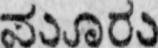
ಮೂರು
